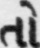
તો
